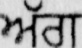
ਅੱਗ
